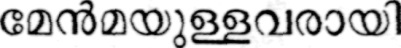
മേന്‍മയുള്ളവരായി
